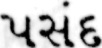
પસંદ
